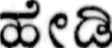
ಹೇಡಿ
